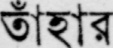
তাঁহার
